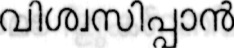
വിശ്വസിപ്പാന്‍
